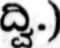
ದ್ವಿ)
